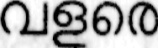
വളരെ
